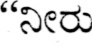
"ನೀರು
